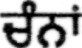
ਚੰਨਾਂ
